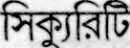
সিক্যুরিটি
